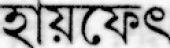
হায়ফেৎ
